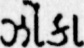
ઝોંકા
